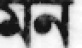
মন
